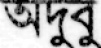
অদুবু
